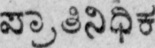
ಪ್ರಾತಿನಿಧಿಕ
